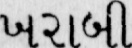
ખરાબી
